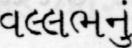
વલ્લભનું
